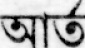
আর্ত
